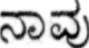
ನಾವು
